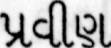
પ્રવીણ
